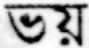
ভয়
